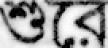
শুরে
